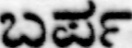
ಬರ್ಪ
